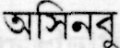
অসিনবু
